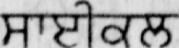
ਸਾਈਕਲ
